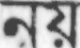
নয়
